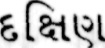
દક્ષિણ
